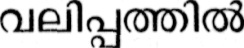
വലിപ്പത്തില്‍
